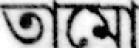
তামো
